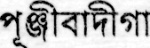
পূঞ্জীবাদীগা
